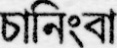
চানিংবা
